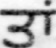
ਤਾਂ
